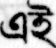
এই
